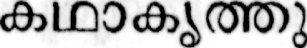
കഥാകൃത്തു
